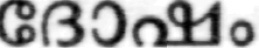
ദോഷം
